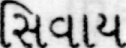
સિવાય
